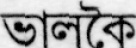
ভালকৈ
